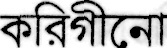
করিগীনো
